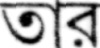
তার
